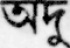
অদু
